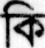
কি
